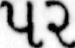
પર
